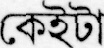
কেইটা
